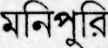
মনিপুরি
